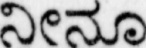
ನೀನೂ
